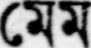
মেম
